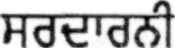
ਸਰਦਾਰਨੀ
